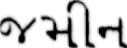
જમીન
